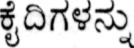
ಕೈದಿಗಳನ್ನು
